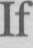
If
